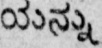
ಯನ್ನು
